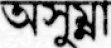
অসুম্না
